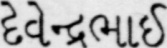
દેવેન્દ્રભાઈ
